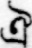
ঐ
